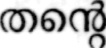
തന്റെ
